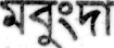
মবুংদা
